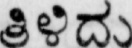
ತಿಳಿದು
